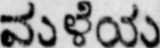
ಮಳೆಯ
